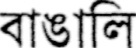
বাঙালি
